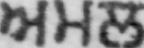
ਅਮਲ
